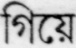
গিয়ে
